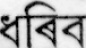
ধৰিব
